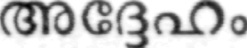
അദ്ദേഹം
